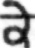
ਕੇ
